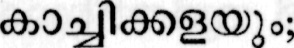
കാച്ചിക്കളയും;
